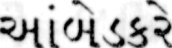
આંબેડકરે
